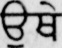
ਉਥੇ
